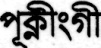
পূক্নীংগী
